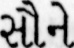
સૌને
